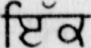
ਇੱਕ
